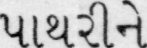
પાથરીને
